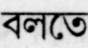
বলতে
